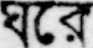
ঘরে
